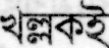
খল্লকই
